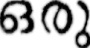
ഒരു
